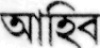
আহিব
